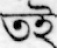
তই
